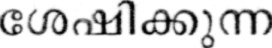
ശേഷിക്കുന്ന
